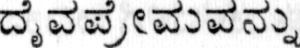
ದೈವಪ್ರೇಮವನ್ನು
